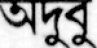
অদুবু
